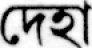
দেহা
